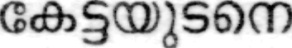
കേട്ടയുടനെ
